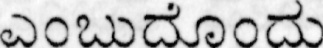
ಎಂಬುದೊಂದು
